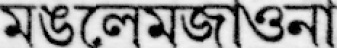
মঙলেমজাওনা
